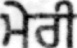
ਮੇਰੀ
